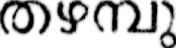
തഴമ്പു
